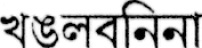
খঙলবনিনা
